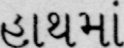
હાથમાં
